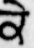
ਕੇ
